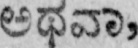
ಅಥವಾ,
